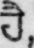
ਹੈ,
